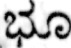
ಭೂ
